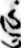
હું
